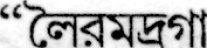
“লৈরমদ্রগা
